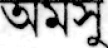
অমসু
